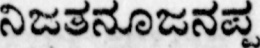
ನಿಜತನೂಜನಪ್ಪ
